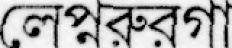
লেপ্নরুরগা
